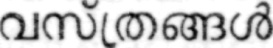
വസ്ത്രങ്ങള്‍
